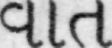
વાત
